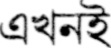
এখনই
